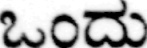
ಒಂದು
